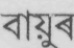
বায়ুৰ
